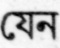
যেন
